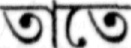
তাতে
